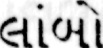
લાંબો
